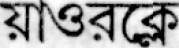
য়াওরক্লে
